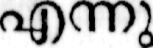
എന്നു
